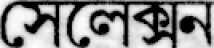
সেলেক্সন
